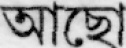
আছো
